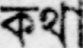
কথা
